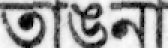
তাঙনা
